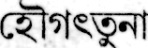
হৌগৎতুনা
